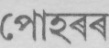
পোহৰৰ
